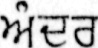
ਅੰਦਰ
